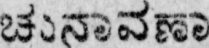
ಚುನಾವಣಾ
